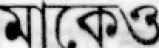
মাকেও
